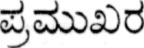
ಪ್ರಮುಖರ
